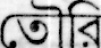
তৌরি
